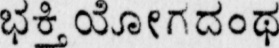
ಭಕ್ತಿಯೋಗದಂಥ
